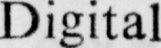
Digital
